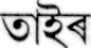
তাইৰ
